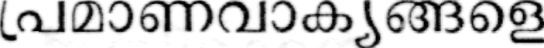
പ്രമാണവാക്യങ്ങളെ
